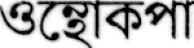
ওন্থোকপা
